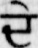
ਦੇ
